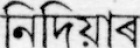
নিদিয়াৰ
